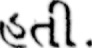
હતી.
